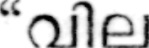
“വില
